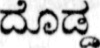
ದೊಡ್ಡ
